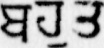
ਬਹੁਤ
